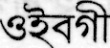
ওইবগী
